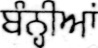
ਬੰਨ੍ਹੀਆਂ
